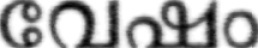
വേഷം
